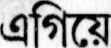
এগিয়ে
